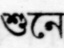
শুনে
